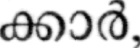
ക്കാര്‍,
